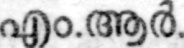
എം.ആര്‍.
